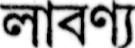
লাবণ্য
